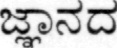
ಜ್ಞಾನದ
